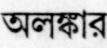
অলঙ্কার
